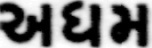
અધમ
